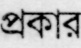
প্রকার
